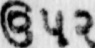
ઉપર
